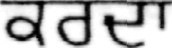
ਕਰਦਾ
